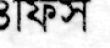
ওফিস
